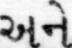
અને
